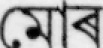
মোৰ
